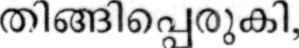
തിങ്ങിപ്പെരുകി,
